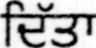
ਦਿੱਤਾ
